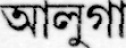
আলুগা
